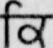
ਕਿ
